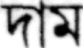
দাম
